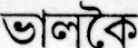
ভালকৈ
